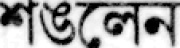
শঙলেন
